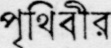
পৃথিবীর
